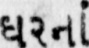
ઘરના
